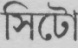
সিটো
